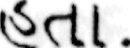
હતા.
